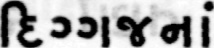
દિગ્ગજનાં
